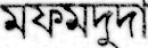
মফমদুদা
